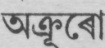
অক্ৰূৰো
